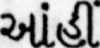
આંહીં
